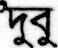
’দুবু
